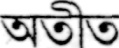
অতীত
